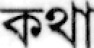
কথা
